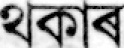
থকাৰ
